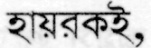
হায়রকই,
